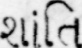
શાંતિ
